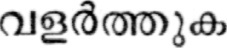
വളര്‍ത്തുക
